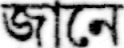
জানে
